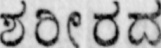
ಶರೀರದ
